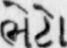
ભેટો
